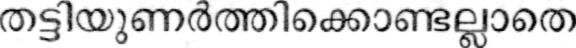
തട്ടിയുണര്‍ത്തിക്കൊണ്ടല്ലാതെ
